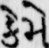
કેમે
